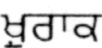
ਖ਼ੁਰਾਕ
